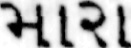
મારા
